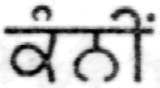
ਕੰਨੀਂ
